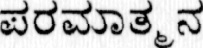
ಪರಮಾತ್ಮನ
